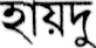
হায়দু
